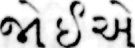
જોઈએ
